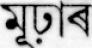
মূঢ়াৰ
